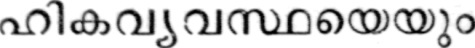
ഹികവ്യവസ്ഥയെയും
